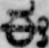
ಈ
